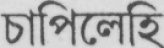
চাপিলেহি
